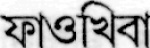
ফাওখিবা
